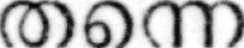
തന്നെ
